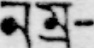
নম্র-
